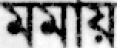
মমায়
